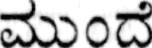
ಮುಂದೆ
